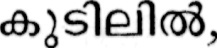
കുടിലില്‍,
